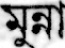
মুন্না
